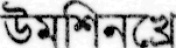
উমশিনখ্রে
